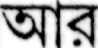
আর
